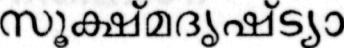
സൂക്ഷ്‌മദ്യഷ്ട്യാ
